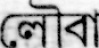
লৌবা
